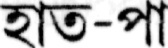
হাত-পা
